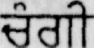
ਚੰਗੀ
